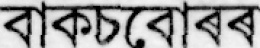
বাকচবোৰৰ
